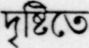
দৃষ্টিতে
